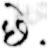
છે.
